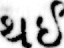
થઈ
